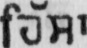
ਹਿੱਸਾ
